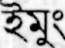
ইমুং
